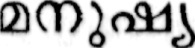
മനുഷ്യ
